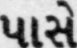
પાસે
